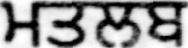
ਮਤਲਬ
